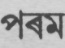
পৰম
